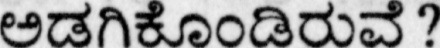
ಅಡಗಿಕೊಂಡಿರುವೆ?
